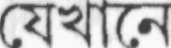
যেখানে
